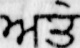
ਅਤੇ
